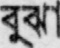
বুঝা
